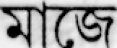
মাজে
